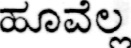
ಹೂವೆಲ್ಲ
